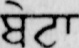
ਬੇਟਾ
